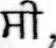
ਸੀ,
